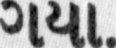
ગયા.
